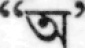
"অ'
